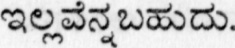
ಇಲ್ಲವೆನ್ನಬಹುದು.
